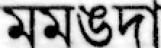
মমঙদা
